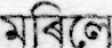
মৰিলে
